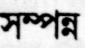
সম্পন্ন
